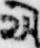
એ
